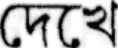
দেখে
